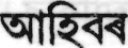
আহিবৰ
